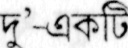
দু’-একটি
